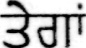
ਤੇਗਾਂ
